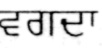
ਵਗਦਾ
